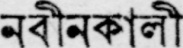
নবীনকালী
